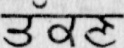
ਤੱਕਣ
